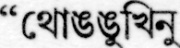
“থোঙঙুখিনু
